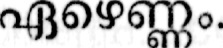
ഏഴെണ്ണം.
